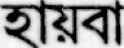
হায়বা
